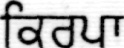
ਕਿਰਪਾ
